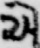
એ
